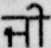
ਜੀ
